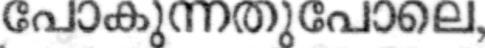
പോകുന്നതുപോലെ,
